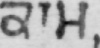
ਕਾਮ,
